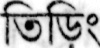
তিড়িং
